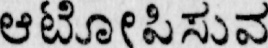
ಆಟೋಪಿಸುವ
